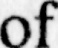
of
